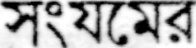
সংযমের
